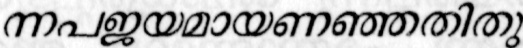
ന്നപജയമായണഞ്ഞതിതു
